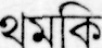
থমকি
